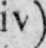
iv)
